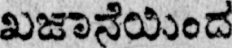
ಖಜಾನೆಯಿಂದ
